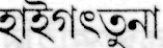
হাইগৎতুনা
